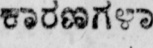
ಕಾರಣಗಳಾ
